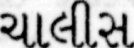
ચાલીસ
